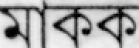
মাকক
